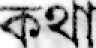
কথা
